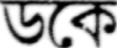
ডকে
